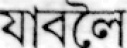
যাবলৈ
